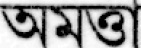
অমত্তা
